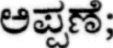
ಅಪ್ಪಣೆ;
